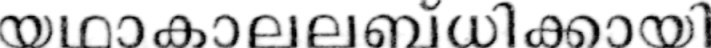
യഥാകാലലബ്ധിക്കായി
